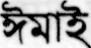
ঈমাই
